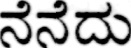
ನೆನೆದು
